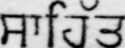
ਸਾਹਿੱਤ
